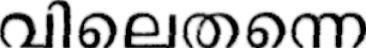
വിലെതന്നെ
